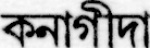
কনাগীদা
